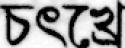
চৎখ্রে
